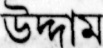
উদ্দাম
